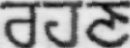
ਰਹਣ
